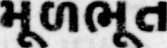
મૂળભૂત
